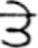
ਤੇ
